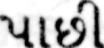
પાછી
